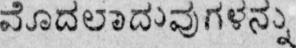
ಮೊದಲಾದುವುಗಳನ್ನು
